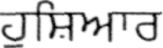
ਹੁਸ਼ਿਆਰ
